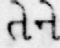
તેને
